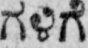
ಗಳಿಗೆ
